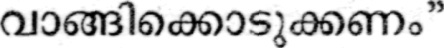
വാങ്ങിക്കൊടുക്കണം”
